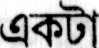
একটা
